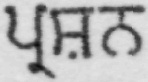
ਪ੍ਰਸ਼ਨ
